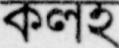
কলহ
